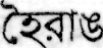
হৈরাঙ
